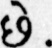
છે.
